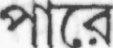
পারে
